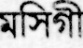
মসিগী
